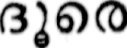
ദൂരെ
